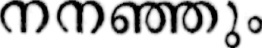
നനഞ്ഞും
